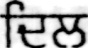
ਦਿਲ
